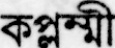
কপ্লম্মী
